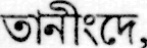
তানীংদে,
